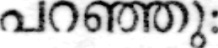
പറഞ്ഞു:
